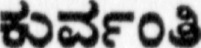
ಕುರ್ವಂತಿ
